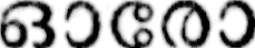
ഓരോ
